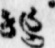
કહું
